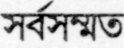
সর্বসম্মত
